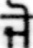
ਜੋ
